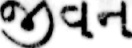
જીવન
